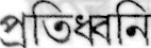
প্রতিধ্বনি
